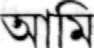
আমি
